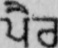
ਪੈਰ
